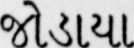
જોડાયા
